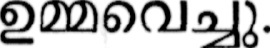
ഉമ്മവെച്ചു.
